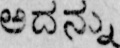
ಅದನ್ನು
